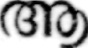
ആ
